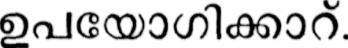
ഉപയോഗിക്കാറ്.
